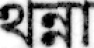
থন্না
